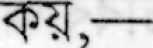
কয়,-
